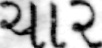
ચાર
